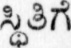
ಸ್ಥಿತಿಗೆ
